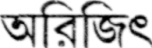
অরিজিৎ
